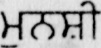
ਮੁਨਸ਼ੀ
